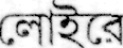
লোইরে
